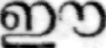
ഈ
